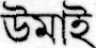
উমাই
